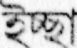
ইচ্ছা
